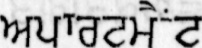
ਅਪਾਰਟਮੈਂਟ
